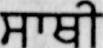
ਸਾਥੀ
